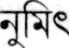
নুমিৎ
